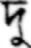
দু
